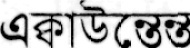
এক্বাউন্তেন্ত
